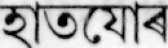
হাতযোৰ
